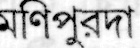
মণিপুরদা
